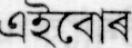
এইবোৰ
